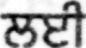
ਲਈ
